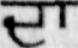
ਦਾ
